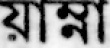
য়াম্না
